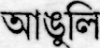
আঙুলি
